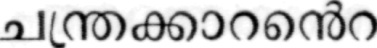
ചന്ത്രക്കാറന്റെ
